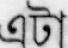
এটা
